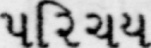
પરિચય
